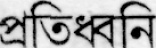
প্রতিধ্বনি
